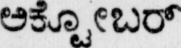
ಅಕ್ಟೋಬರ್
